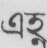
এহ্ণ
